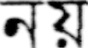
নয়
